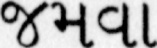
જમવા
